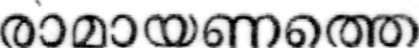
രാമായണത്തെ
